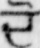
ਦੋ
